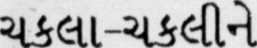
ચકલા-ચકલીને
